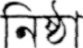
নিষ্ঠা
